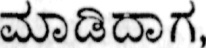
ಮಾಡಿದಾಗ,
